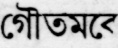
গৌতমবে
